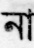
না
